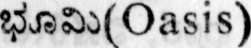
ಭೂಮಿ(Oasis)
